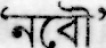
'নবৌ'
